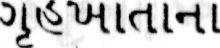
ગૃહખાતાના
